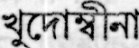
খুদোম্বীনা
